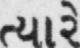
ત્યારે
